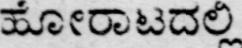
ಹೋರಾಟದಲ್ಲಿ
